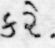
કરે.
